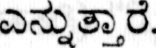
ಎನ್ನುತ್ತಾರೆ.
